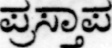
ಪ್ರಸ್ತಾಪ
